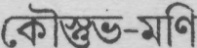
কৌস্তুভ-মণি
